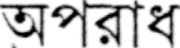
অপরাধ
